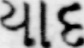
યાદ
